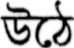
উঠে
